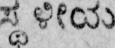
ಸ್ಥಳೀಯ
